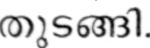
തുടങ്ങി.
